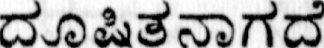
ದೂಷಿತನಾಗದೆ
